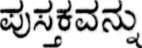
ಪುಸ್ತಕವನ್ನು
